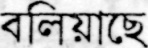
বলিয়াছে
